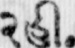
રહી.
